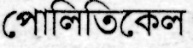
পোলিতিকেল
